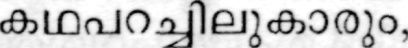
കഥപറച്ചിലുകാരും,
